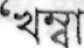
‘খম্বা
